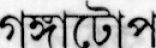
গঙ্গাটোপ
